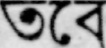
তবে
